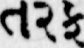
તરફ
